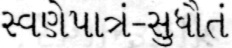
સ્વણેપાત્રં-સુધૌતં
